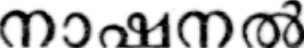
നാഷനല്‍
